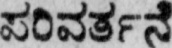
ಪರಿವರ್ತನೆ
